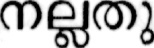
നല്ലതു
